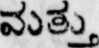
ಮತ್ತು
